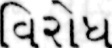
વિરોધ
